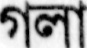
গলা
